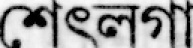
শেৎলগা
